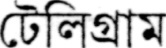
টেলিগ্রাম
